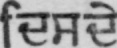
ਦਿਸਦੇ
